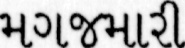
મગજમારી
